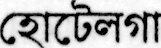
হোটেলগা
